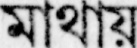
মাথায়
